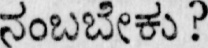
ನಂಬಬೇಕು?
